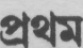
প্ৰথম
